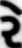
રે
